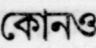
কোনও
